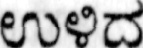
ಉಳಿದ
